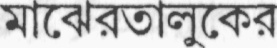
মাঝেরতালুকের
